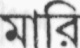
মারি
